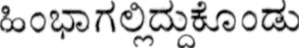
ಹಿಂಭಾಗಲ್ಲಿದ್ದುಕೊಂಡು
